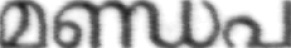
മണ്ഡപ
